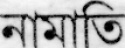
নামাতি
